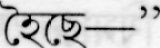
হৈছে-"
